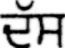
ਦੱਸ
